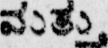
ಮತ್ತು
